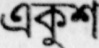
একুশ
